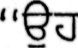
''ਉਹ
